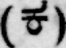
(ಕ)
